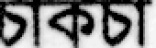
চাকচা
